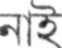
নাই
